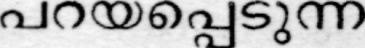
പറയപ്പെടുന്ന
